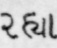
રહ્યા
